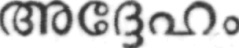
അദ്ദേഹം
